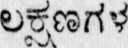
ಲಕ್ಷಣಗಳ
